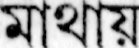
মাথায়
